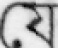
যে
